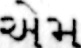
એમ
